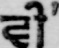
ਵੀ'
